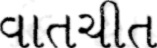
વાતચીત
